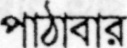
পাঠাবার
